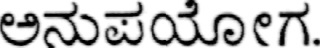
ಅನುಪಯೋಗ.
